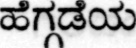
ಹೆಗ್ಗಡೆಯ
